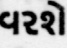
વરશે
